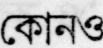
কোনও
